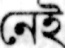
নেই
